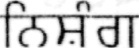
ਨਿਸ਼ੰਗ
